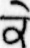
ਕੇ
